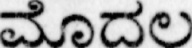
ಮೊದಲ
